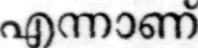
എന്നാണ്
